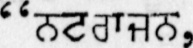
''ਨਟਰਾਜਨ,
